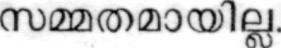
സമ്മതമായില്ല.
